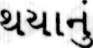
થયાનું
